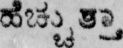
ಹೆಚ್ಚುತ್ತಾ
